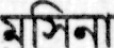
মসিনা
